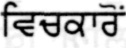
ਵਿਚਕਾਰੋਂ
